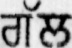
ਗੱਲ
